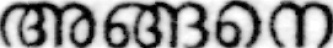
അങ്ങനെ
